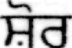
ਸ਼ੋਰ
